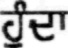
ਹੁੰਦਾ
